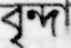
বৃন্দা
